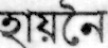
হায়নৈ
